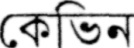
কেভিন
